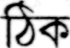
ঠিক
